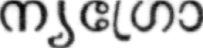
ന്യഗ്രോ
